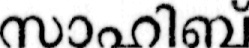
സാഹിബ്
